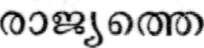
രാജ്യത്തെ
